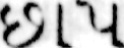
છાપ
